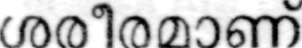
ശരീരമാണ്
